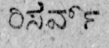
ರಿಸರ್ವ್
